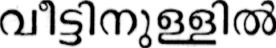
വീട്ടിനുള്ളില്‍
